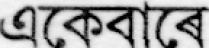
একেবাৰে
